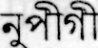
নুপীগী
